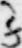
કે
